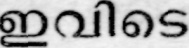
ഇവിടെ
